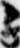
કે
